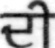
ਦੀ
